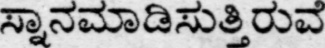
ಸ್ನಾನಮಾಡಿಸುತ್ತಿರುವೆ
